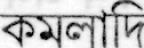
কমলদি
